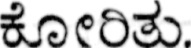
ಕೋರಿತು.
